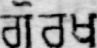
ਗੋਰਖ
